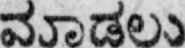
ಮಾಡಲು
